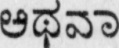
ಅಥವಾ
